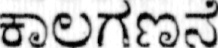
ಕಾಲಗಣನೆ
